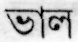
ভাল
